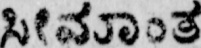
ಸೀಮಾಂತ
